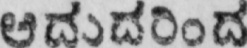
ಆದುದರಿ೦ದ
